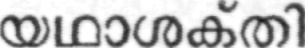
യഥാശക്തി
